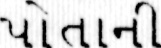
પોતાની
